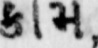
કામ,
